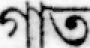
গাত
